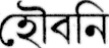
হৌবনি
